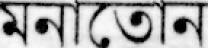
মনাতোন
